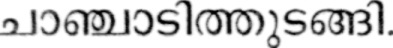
ചാഞ്ചാടിത്തുടങ്ങി.
